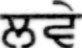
ਲਵੇ
